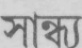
সান্ধ্য
